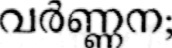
വര്‍ണ്ണന;
